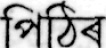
পিঠিৰ
